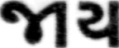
જાય
